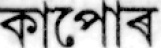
কাপোৰ
